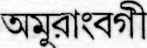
অমুরাংবগী
